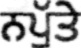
ਨਪੁੱਤੇ
